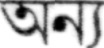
অন্য
